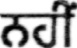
ਨਹੀਂ
